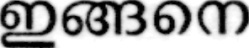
ഇങ്ങനെ
